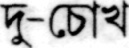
দু-চোখ
